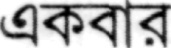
একবার
